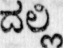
ದಲ್ಲಿ
